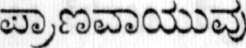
ಪ್ರಾಣವಾಯುವು
